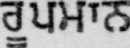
ਰੂਪਮਾਨ
